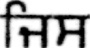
ਜਿਸ
